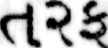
તરફ
